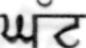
ਘੱਟ
